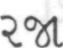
રજા
